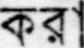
করা
